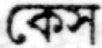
কেস
